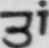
ਤਾਂ
